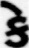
કે
